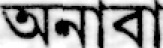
অনাবা
